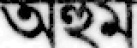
অহুম
